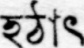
হঠাৎ
